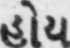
હોય
